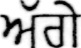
ਅੱਗੇ
